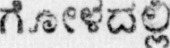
ಗೋಳದಲ್ಲಿ
